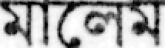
মালেম
